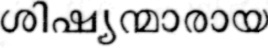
ശിഷ്യന്മാരായ
